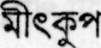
মীৎকুপ
